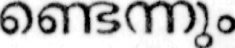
ണ്ടെന്നും
